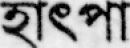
হাৎপা
